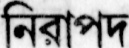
নিরাপদ
